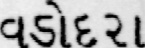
વડોદરા
